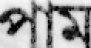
পাম
